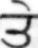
ਤੇ
